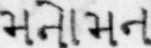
મનોમન
